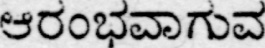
ಆರಂಭವಾಗುವ
